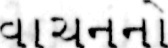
વાચનનો
